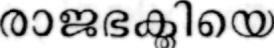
രാജഭക്തിയെ
